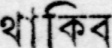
থাকিব
